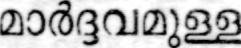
മാര്‍ദ്ദവമുള്ള
